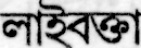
লাইবক্তা
